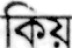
কিয়
